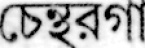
চেন্থরগা
